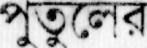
পুতুলের
